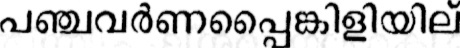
പഞ്ചവര്‍ണപ്പൈങ്കിളിയില്
